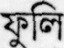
ফুলি
